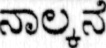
ನಾಲ್ಕನೆ
